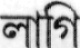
লাগি
